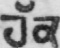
ਹੱਕ
